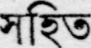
সহিত
